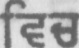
ਵਿਚ
